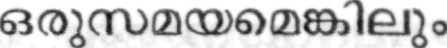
ഒരുസമയമെങ്കിലും
